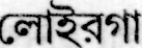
লোইরগা
